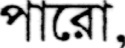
পারো,
